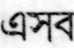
এসব
